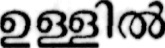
ഉള്ളില്‍
